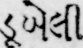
ડૂબેલી
